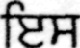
ਇਸ
